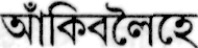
আঁকিবলৈহে
